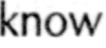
know
